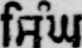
ਸਿੰਘ
